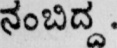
ನಂಬಿದ್ದ.
